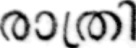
രാത്രി
